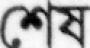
শেষ
